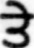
ਤੇ
